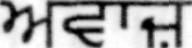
ਅਵਾਜ਼
